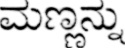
ಮಣ್ಣನ್ನು
